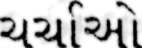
ચર્ચાઓ
